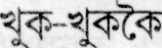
খুক-খুককৈ
